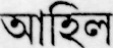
আহিল
